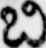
ಬಿ
